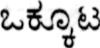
ಒಕ್ಕೂಟ
